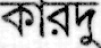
কারদু
